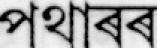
পথাৰৰ
